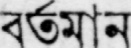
বর্তমান
